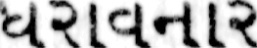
ધરાવનાર
